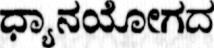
ಧ್ಯಾನಯೋಗದ
